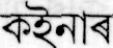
কইনাৰ
